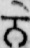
ਨੇ
